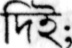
দিই;
